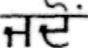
ਜਦੋਂ
